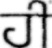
ਹੀ
